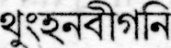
থুংহনবীগনি
